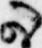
જે
